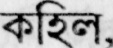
কহিল,
